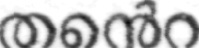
തന്റെ
